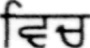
ਵਿਚ
